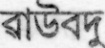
ৱাউবদু
